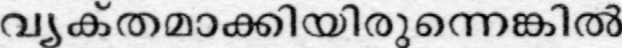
വ്യക്തമാക്കിയിരുന്നെങ്കില്‍
